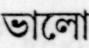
ভালো
